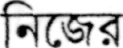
নিজের
